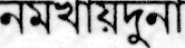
নমখায়দুনা
